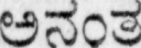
ಅನಂತ
